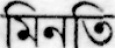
মিনতি
